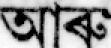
আৰু
